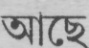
আছে
